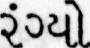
રંગ્યો
